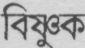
বিষ্ণুক
